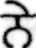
ਨੇ
